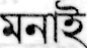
মনাই
